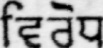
ਵਿਰੋਧ
